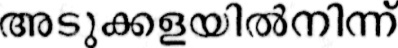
അടുക്കളയില്‍നിന്ന്
